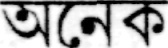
অনেক
